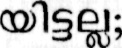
യിട്ടല്ല;
